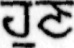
ਹੁਣ
